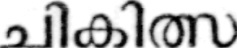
ചികിത്സ
